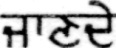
ਜਾਣਦੇ
